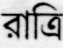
রাত্রি
